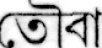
তৌবা
